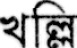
খল্লি
